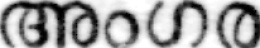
അംഗര
